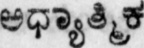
ಅಧ್ಯಾತ್ಮಿಕ
